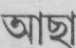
আছা
